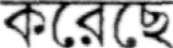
করেছে
